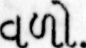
વળો.
